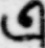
এ
